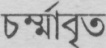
চৰ্ম্মাবৃত
